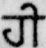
ਹੀ
